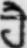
ਹੈ
